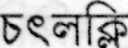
চৎলক্লি
